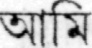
আমি
